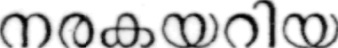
നരകയറിയ
